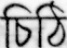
চিঠি
